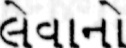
લેવાનો
